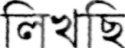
লিখছি
